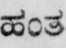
ಹಂತ
